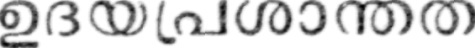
ഉദയപ്രശാന്തത
